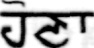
ਹੋਣਾ
